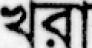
খরা
